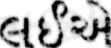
લઈએ
